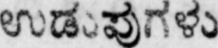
ಉಡುಪುಗಳು
